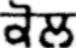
ਕੋਲ
